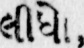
લીધો,
